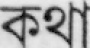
কথা
